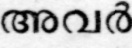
അവര്‍
